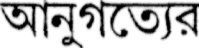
আনুগত্যের
